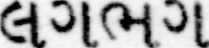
લગભગ
